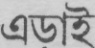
এড়াই
